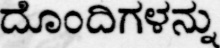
ದೊಂದಿಗಳನ್ನು
